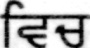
ਵਿਚ
